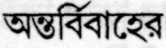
অন্তর্বিবাহের
